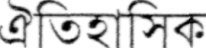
ঐতিহাসিক
